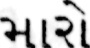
મારો
